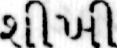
શીખી
